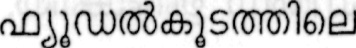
ഫ്യൂഡല്‍കൂടത്തിലെ
